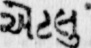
એટલું
